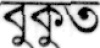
বুকুত
